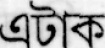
এটাক
